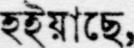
হইয়াছে,
